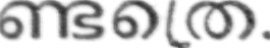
ണ്ടത്രെ.
